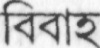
বিবাহ
